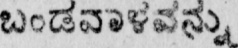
ಬಂಡವಾಳವನ್ನು
